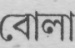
বোলা
